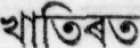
খাতিৰত
